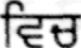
ਵਿਚ
